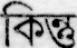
কিন্তু
